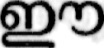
ഈ
